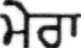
ਮੇਰਾ
